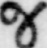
જ
